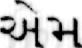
એમ
